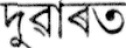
দুৱাৰত
